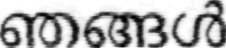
ഞങ്ങള്‍
